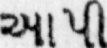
આપી
